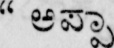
“ಅಪ್ಪಾ
